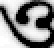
ও
